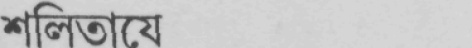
শলিতাযে
